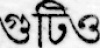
গুটিও
